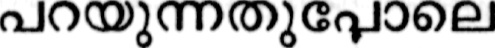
പറയുന്നതുപോലെ
